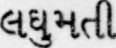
લઘુમતી
